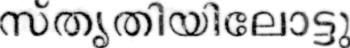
സ്തൃതിയിലോട്ടു
